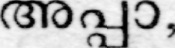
അപ്പാ,
